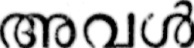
അവള്‍
